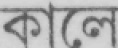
কালে
